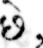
છે,
